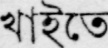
খাইতে
